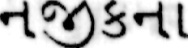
નજીકના
